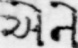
એને
